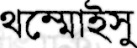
থম্মোইসু
